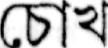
চোখ
